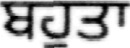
ਬਹੁਤਾ
